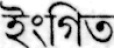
ইংগিত
